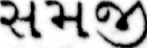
સમજી
